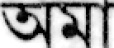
অমা
